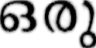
ഒരു
